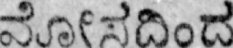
ಮೋಸದಿಂದ
